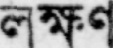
লক্ষণ
